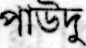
পাউদু
